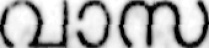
വാസ
